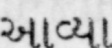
આવ્યા
